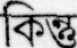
কিন্তু
